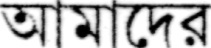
আমাদের
